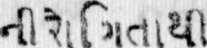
નીરોગિતાથી
